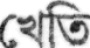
খেতি
